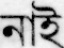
নাই
